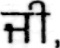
ਜੀ,
